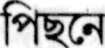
পিছনে
